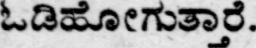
ಓಡಿಹೋಗುತ್ತಾರೆ.
